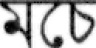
মচে
